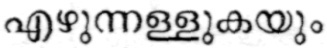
എഴുന്നള്ളുകയും
